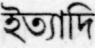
ইত্যাদি
